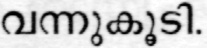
വന്നുകൂടി.
